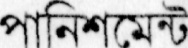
পানিশমেন্ট
